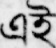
এই
